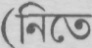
(নিতে
